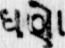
ઘણો
